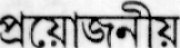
প্রয়োজনীয়
